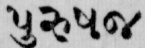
પુરુષજ
